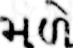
મળે
